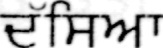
ਦੱਸਿਆ
